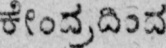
ಕೇಂದ್ರದಿಂದ
